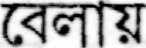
বেলায়
